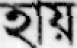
হায়
